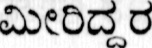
ಮೀರಿದ್ದರ
